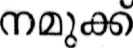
നമുക്ക്
